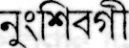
নুংশিবগী
